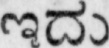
ಇದು
